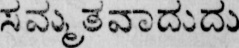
ಸಮ್ಮತವಾದುದು
